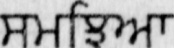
ਸਮਝਿਆ
